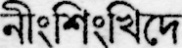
নীংশিংখিদে
